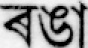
ৰঙা
